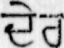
ਦੇਰ
